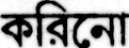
করিনো
